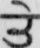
ਤੇ
